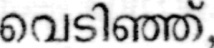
വെടിഞ്ഞ്,
